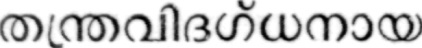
തന്ത്രവിദഗ്ധനായ
